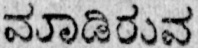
ಮಾಡಿರುವ
